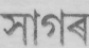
সাগৰ
